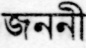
জননী
